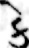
કે
